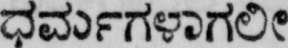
ಧರ್ಮಗಳಾಗಲೀ
